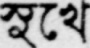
সুখে
